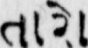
તારો
